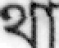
থা
